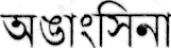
অঙাংসিনা
